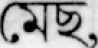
মেছ,
